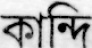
কান্দি
